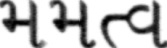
મમત્વ
